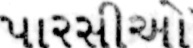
પારસીઓ
